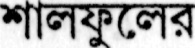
শালফুলের
